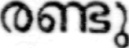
രണ്ടു
